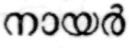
നായര്‍
